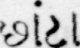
છાંટા
